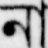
না
